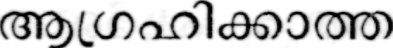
ആഗ്രഹിക്കാത്ത
